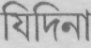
যিদিনা
